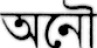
অনৌ
